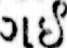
ગઈ
